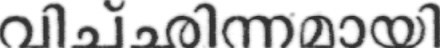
വിച്ഛിന്നമായി
